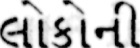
લોકોની
